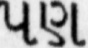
પણ
